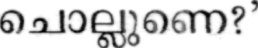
ചൊല്ലുണെ?'
